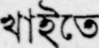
খাইতে
